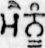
ਮੈਨੂੰ
